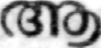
ആ
